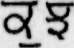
ਕੁਝ
